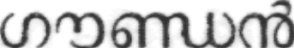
ഗൗണ്ഡന്‍
